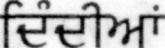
ਦਿੰਦੀਆਂ
